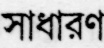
সাধারণ
